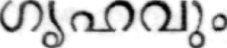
ഗൃഹവും
